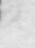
છે
